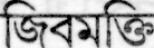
জিবমক্তি
